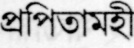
প্রপিতামহী
